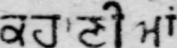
ਕਹਾਣੀਆਂ
